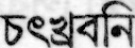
চৎখ্রবনি
